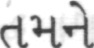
તમને
